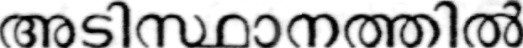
അടിസ്ഥാനത്തില്‍
